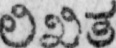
ಲಿಖಿತ
